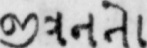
જીવનનો
